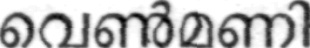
വെണ്‍മണി
